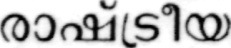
രാഷ്ട്രീയ
